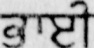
ਭਾਈ
